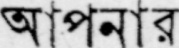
আপনার
